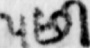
પછી
